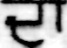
ਦਾ
